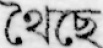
থৈছে
